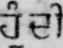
ਹੁੰਦੀ
